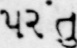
પરંતુ
